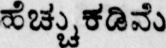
ಹೆಚ್ಚುಕಡಿಮೆ
